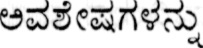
ಅವಶೇಷಗಳನ್ನು
